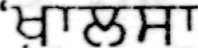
'ਖ਼ਾਲਸਾ
